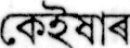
কেইষাৰ
